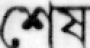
শেষ
